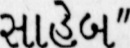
સાહેબ"
